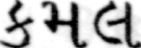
કમલ
